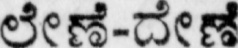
ಲೇಣೆ-ದೇಣೆ
